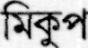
মিকুপ
